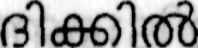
ദിക്കില്‍
